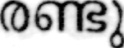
രണ്ടു
